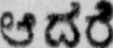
ಆದರೆ
